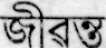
জীৱন্ত
